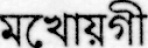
মখোয়গী
